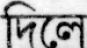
দিলে
